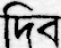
দিব
